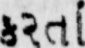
કરતાં
